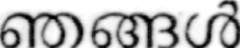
ഞങ്ങള്‍
